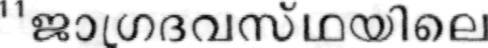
11ജാഗ്രദവസ്ഥയിലെ
